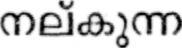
നല്കുന്ന
